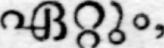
ഏറ്റും,
